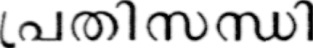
പ്രതിസന്ധി
